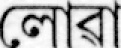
লোৱা
